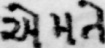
એમને
